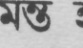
মন্ত
